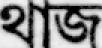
থাজ
